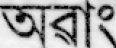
অৱাং
